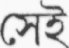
সেই
